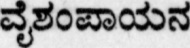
ವೈಶಂಪಾಯನ
